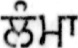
ਲੰਮਾ
